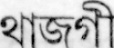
থাজগী
